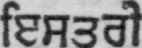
ਇਸਤਰੀ
